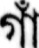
গাঁ
